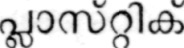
പ്ലാസ്റ്റിക്
